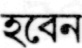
হবেন
